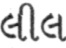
લીલ
